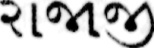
રાજાજી
